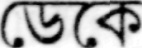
ডেকে
